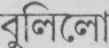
বুলিলো
